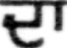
ਦਾ
